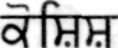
ਕੋਸ਼ਿਸ਼
